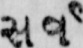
સર્વ
